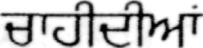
ਚਾਹੀਦੀਆਂ
